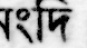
নংদি
